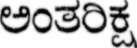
ಅಂತರಿಕ್ಷ
